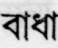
বাধা
